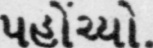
પહોંચ્યો.
